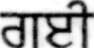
ਗਈ
